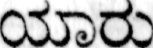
ಯಾರು
